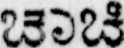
ಚಾಚಿ
